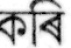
কৰি
